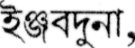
ইঞ্জবদুনা,
